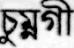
চুম্নগী
